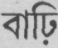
বাঢ়ি
